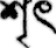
শৃৎ
